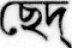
ছেদ্
